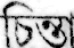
চিন্তা
